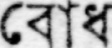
বোধ
